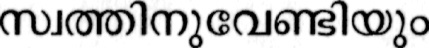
സ്വത്തിനുവേണ്ടിയും
